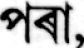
পৰা,
